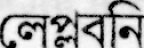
লেপ্লবনি
